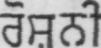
ਰੋਸ਼ਨੀ
